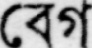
বেগ
